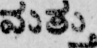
ಮತ್ತು
